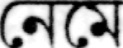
নেমে
